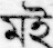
মই
